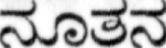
ನೂತನ
